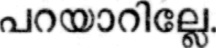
പറയാറില്ലേ.
